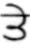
ਤੇ
